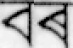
বৰ
